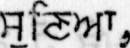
ਸੁਣਿਆ,
